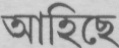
আহিছে
